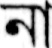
না
